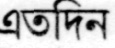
এতদিন
